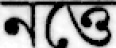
নত্তে
